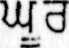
ਘੂਰ
